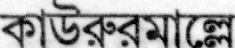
কাউরুরমাল্লে
